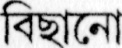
বিছানো
